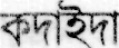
কদাইদা
